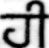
ਹੀ
